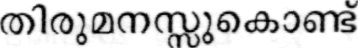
തിരുമനസ്സുകൊണ്ട്
